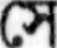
সে
